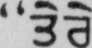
''ਤੇਰੇ
